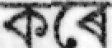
কৰে
